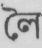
লৈ
